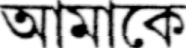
আমাকে
